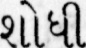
શોધી
